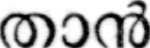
താന്‍
